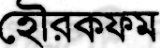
হৌরকফম
